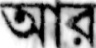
আর
